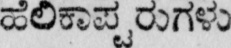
ಹೆಲಿಕಾಪ್ಟರುಗಳು
